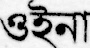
ওইনা
